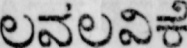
ಲವಲವಿಕೆ
